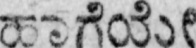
ಹಾಗೆಯೇ
